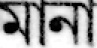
মানা
